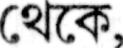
থেকে,
